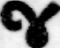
જ
